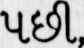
પછી,
